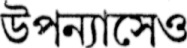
উপন্যাসেও
